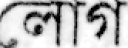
লোগ
